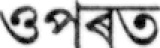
ওপৰত
